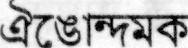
ঐঙোন্দমক
